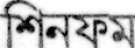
শিনফম
